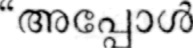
"അപ്പോള്‍
